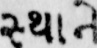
સ્થાનો
